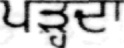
ਪੜ੍ਹਦਾ
